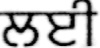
ਲਈ
